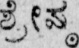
ಶ್ರೇಷ್ಠ
